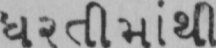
ધરતીમાંથી
